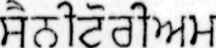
ਸੈਨੀਟੋਰੀਅਮ
